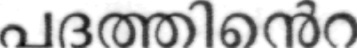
പദത്തിന്റെ
